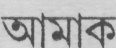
আমাক
